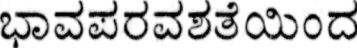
ಭಾವಪರವಶತೆಯಿಂದ
